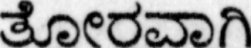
ತೋರವಾಗಿ
